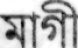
মাগী
